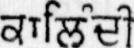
ਕਾਲਿੰਦੀ
